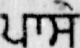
ਪਾਸੇ
